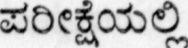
ಪರೀಕ್ಷೆಯಲ್ಲಿ
